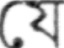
যে
